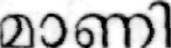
മാണി
